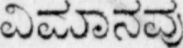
ವಿಮಾನವು
